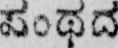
ಪಂಥದ
